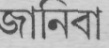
জানিবা
